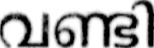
വണ്ടി
